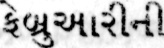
ફેબ્રુઆરીની
